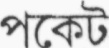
পকেট
